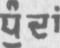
ਧੁੰਦਾਂ
